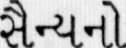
સૈન્યનો
